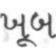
ખૂબ
